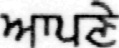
ਆਪਣੇ
